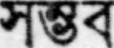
সম্ভব
